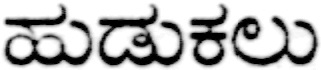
ಹುಡುಕಲು
